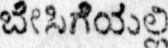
ಬೇಸಿಗೆಯಲ್ಲಿ
